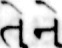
તેને
